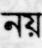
নয়
